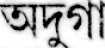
অদুগা
